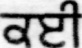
ਕਈ
